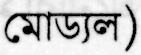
মোড্যল)
